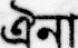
ঐনা
